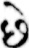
છે
